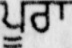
ਪੂਰਾ
